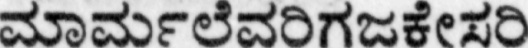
ಮಾರ್ಮಲೆವರಿಗಜಕೇಸರಿ
